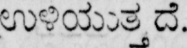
ಉಳಿಯುತ್ತದೆ.
